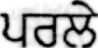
ਪਰਲੇ
